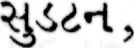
સુડટન,
